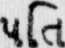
પતિ
